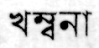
খম্বনা
